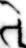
તે
